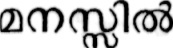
മനസ്സില്‍
